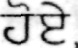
ਹੋਏ,
